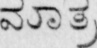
ಮಾತ್ರ
